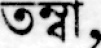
তম্বা,
